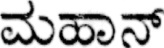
ಮಹಾನ್
